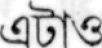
এটাও
